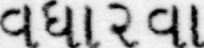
વધારવા
